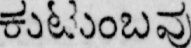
ಕುಟುಂಬವು
